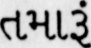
તમારૂં
